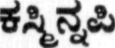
ಕಸ್ಮಿನ್ನಪಿ
